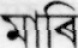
মাৰি
